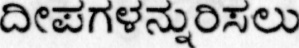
ದೀಪಗಳನ್ನುರಿಸಲು
